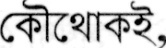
কৌথোকই,
